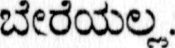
ಬೇರೆಯಲ್ಲ.
